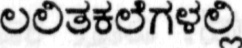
ಲಲಿತಕಲೆಗಳಲ್ಲಿ
